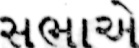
સભાએ
